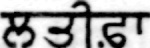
ਲਤੀਫ਼ਾ
